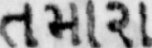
તમારા
